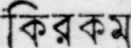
কিরকম
